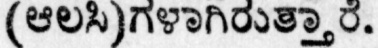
(ಆಲಸಿ)ಗಳಾಗಿರುತ್ತಾರೆ.
